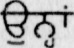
ਉਨ੍ਹਾਂ
